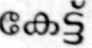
കേട്ട്
